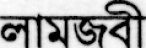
লামজবী
